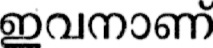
ഇവനാണ്
